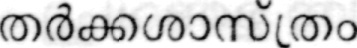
തര്‍ക്കശാസ്ത്രം
